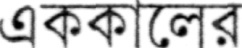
এককালের
